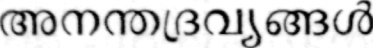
അനന്തദ്രവ്യങ്ങള്‍
